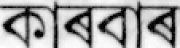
কাৰবাৰ
